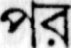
পর
